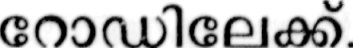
റോഡിലേക്ക്.
